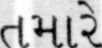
તમારે
